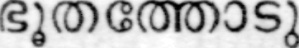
ഭൂതത്തോടു
